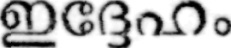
ഇദ്ദേഹം
